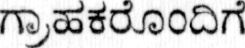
ಗ್ರಾಹಕರೊಂದಿಗೆ
